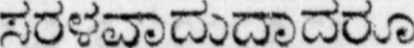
ಸರಳವಾದುದಾದರೂ
